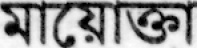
মায়োক্তা
